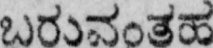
ಬರುವಂತಹ
